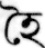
হৈ
